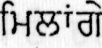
ਮਿਲਾਂਗੇ
